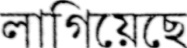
লাগিয়েছে
